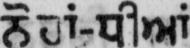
ਨੋਹਾਂ-ਧੀਆਂ
